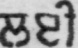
ਲਈ
